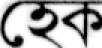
হেক
